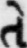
તે
